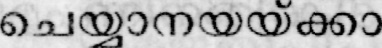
ചെയ്യാനയയ്ക്കാ
